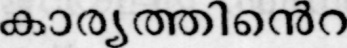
കാര്യത്തിന്റെ
